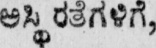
ಅಸ್ಥಿರತೆಗಳಿಗೆ,
